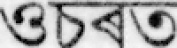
ওচৰত
